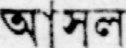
আসল
